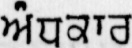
ਅੰਧਕਾਰ
